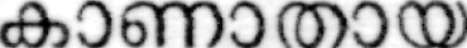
കാണാതായ
